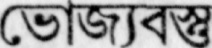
ভোজ্যবস্তু
